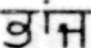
ਭਾਂਜ
